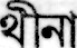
থীনা
